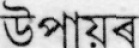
উপায়ৰ
